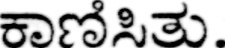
ಕಾಣಿಸಿತು.
